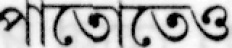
পাতোতেও
